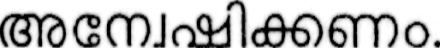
അന്വേഷിക്കണം.
